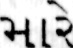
મારે
